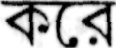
করে
